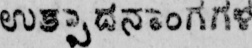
ಉತ್ಪಾದನಾಂಗಗಳ
